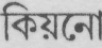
কিয়নো
